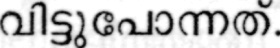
വിട്ടുപോന്നത്.
